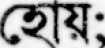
হোয়;
